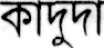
কাদুদা
